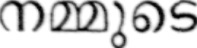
നമ്മുടെ
